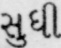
સુધી
